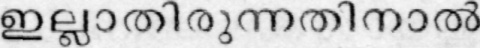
ഇല്ലാതിരുന്നതിനാല്‍
